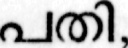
പതി,
